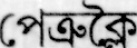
পেত্রুক্লৈ
